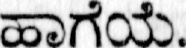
ಹಾಗೆಯೆ.
